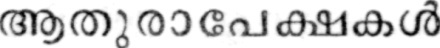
ആതുരാപേക്ഷകള്‍
